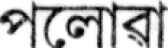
পলোৱা
